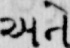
અને
